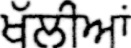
ਖੱਲੀਆਂ
